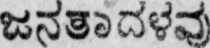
ಜನತಾದಳವು
